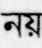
নয়
